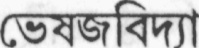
ভেষজবিদ্যা
